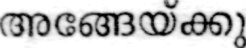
അങ്ങേയ്ക്കു
